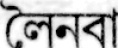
লৈনবা
